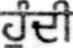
ਹੁੰਦੀ
